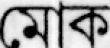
মোক
